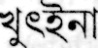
খুৎইনা
